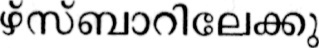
ഴ്സ്ബാറിലേക്കു
